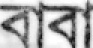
বাবা
